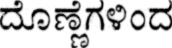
ದೊಣ್ಣೆಗಳಿಂದ
